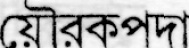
য়ৌরকপদা
